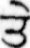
ਤੇ
